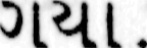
ગયા.
